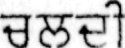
ਚਲਦੀ
